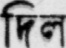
দিল
